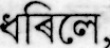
ধৰিলে,
